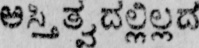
ಅಸ್ತಿತ್ವದಲ್ಲಿಲ್ಲದ
